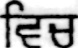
ਵਿਚ
